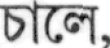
চালে,
